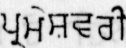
ਪ੍ਰਮੇਸ਼ਵਰੀ
